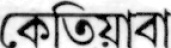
কেতিয়াবা
